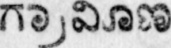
ಗ್ರಾಮೀಣ
